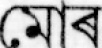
মোৰ
